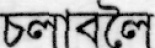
চলাবলৈ
